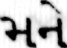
મને
